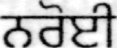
ਨਰੋਈ
